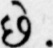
છે.
